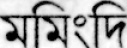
মমিংদি
